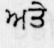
ਅਤੇ
